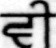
ਵੀ
